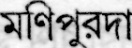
মণিপুরদা
